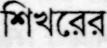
শিখরের
